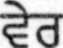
ਵੇਰ
